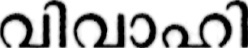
വിവാഹി
